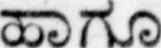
ಹಾಗೂ
